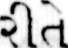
રીતે
